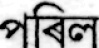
পৰিল
